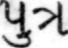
પુત્ર
